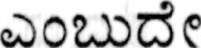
ಎಂಬುದೇ
